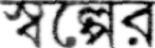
স্বল্পের
